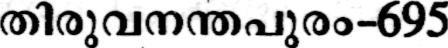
തിരുവനന്തപുരം-695
